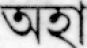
অহা
